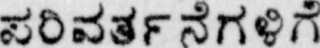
ಪರಿವರ್ತನೆಗಳಿಗೆ
